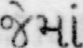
જેમાં
